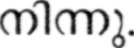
നിന്നു.
